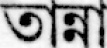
তান্না
